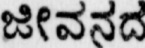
ಜೀವನದ
